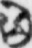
છે
